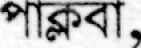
পাক্লবা,
